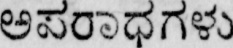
ಅಪರಾಧಗಳು
